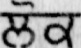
ਲੋਕ
